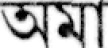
অমা
